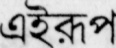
এইরূপ
